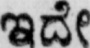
ಇದೇ
